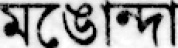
মঙোন্দা
